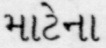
માટેના
